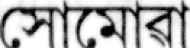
সোমোৱা
